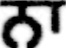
ਨਾ
